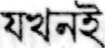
যখনই
